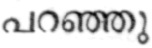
പറഞ്ഞു
